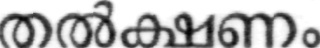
തല്‍ക്ഷണം
